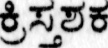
ಕ್ರಿಸ್ತಶಕ
